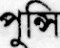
পুন্সি
